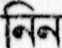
নিন
